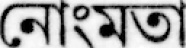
নোংমতা
